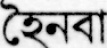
হৈনবা
